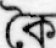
কৈ
